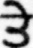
ਤੇ
